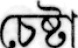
চেষ্টা
